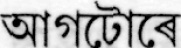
আগটোৰে
